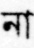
না
